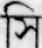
সি
